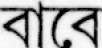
বাবে
